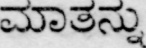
ಮಾತನ್ನು
